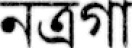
নত্রগা
